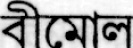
বীমোল
